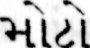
મોટો
